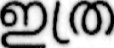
ഇത്ര
